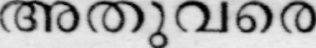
അതുവരെ
